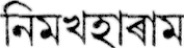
নিমখহাৰাম
